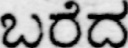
ಬರೆದ
